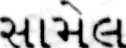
સામેલ
